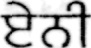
ਏਨੀ
